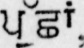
ਪੁੱਛਾਂ,
